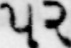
પર
